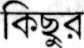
কিছুর
